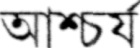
আশ্চর্য
